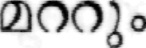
മററും
